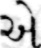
એ
